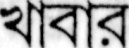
খাবার
